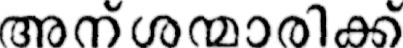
അന്ശന്മാരിക്ക്
